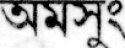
অমসুং
